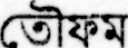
তৌফম
